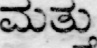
ಮತ್ತು
